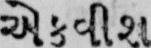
એકવીશ
